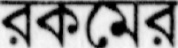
রকমের
